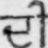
ਦੀ
